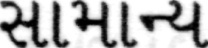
સામાન્ય
